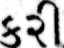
કરી
